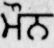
ਮੌਨ
